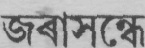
জৰাসন্ধে
